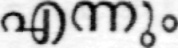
എന്നും
